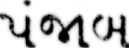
પંજાબ
